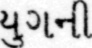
યુગની
